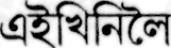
এইখিনিলৈ
